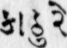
કાઠુરે
